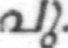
പു.
